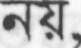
নয়,
